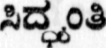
ಸಿದ್ಧ್ಯಂತಿ
